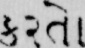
કરતો
